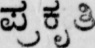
ಪ್ರಕೃತಿ
